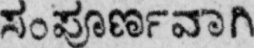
ಸಂಪೂರ್ಣವಾಗಿ
